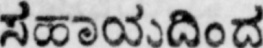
ಸಹಾಯದಿಂದ
